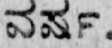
ವರ್ಷ.
